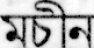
মচীন
